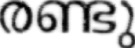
രണ്ടു
